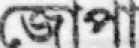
জোপা
